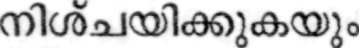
നിശ്ചയിക്കുകയും
